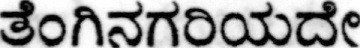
ತೆಂಗಿನಗರಿಯದೇ
